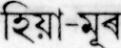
হিয়া-মূৰ
